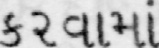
કરવામાં
